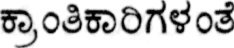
ಕ್ರಾಂತಿಕಾರಿಗಳಂತೆ
